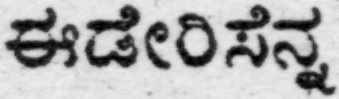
ಈಡೇರಿಸೆನ್ನ
